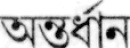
অন্তর্ধান
